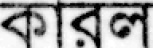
কারল
